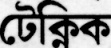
টেক্নিক
